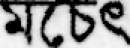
মচেৎ
